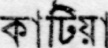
কাটিয়া
